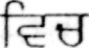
ਵਿਚ
